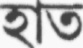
হাত
